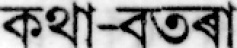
কথা-বতৰা
